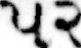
પર
